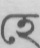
হে
